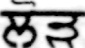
ਲੋੜ
